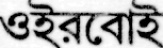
ওইরবোই
